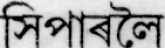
সিপাৰলৈ
